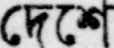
দেশে
